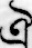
ঐ
